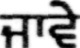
ਜਾਵੇ
